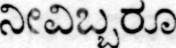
ನೀವಿಬ್ಬರೂ
